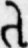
તે
